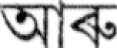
আৰু
